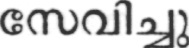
സേവിച്ചു
